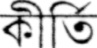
কীর্তি
